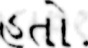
હતો.
